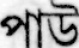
পাউ
